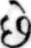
છે
